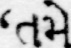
'તમે
